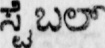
ಸ್ಟೆಬಲ್
